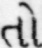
તો
